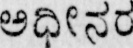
ಅಧೀನರ
